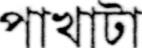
পাখাটা
